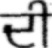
ਦੀ
